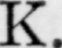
K.
